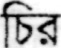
চির
